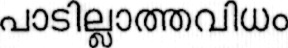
പാടില്ലാത്തവിധം
